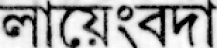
লায়েংবদা
